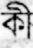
কী
